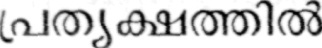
പ്രത്യക്ഷത്തില്‍
